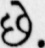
છે.
